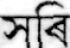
সৰি
